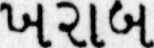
ખરાબ
